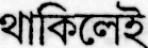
থাকিলেই
